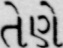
તેણે
